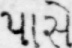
પાસે
